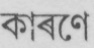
কাৰণে
